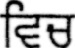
ਵਿਚ
